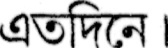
এতদিনে।
